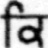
ਕਿ
